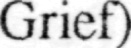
Grief)
